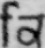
ਕਿ
